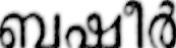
ബഷീര്‍
